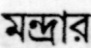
মন্দ্রার
